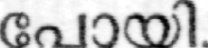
പോയി.
